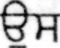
ਉਸ
